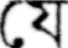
যে
